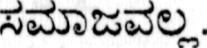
ಸಮಾಜವಲ್ಲ.
